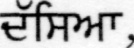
ਦੱਸਿਆ,
